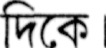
দিকে।
